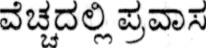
ವೆಚ್ಚದಲ್ಲಿಪ್ರವಾಸ
